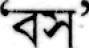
‘বস’
